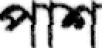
পাশ
